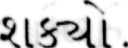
શક્યો.
